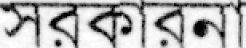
সরকারনা
